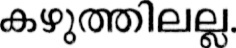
കഴുത്തിലല്ല.
